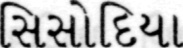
સિસોદિયા
